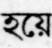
হয়ে
